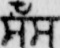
ਸੱਸ
